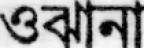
ওজানা
